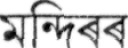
মন্দিৰৰ
